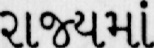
રાજ્યામાં
